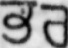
ਭਰ
